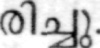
രിച്ചു.
